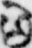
છે
